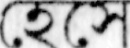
হেসে
